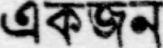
একজন
